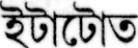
ইটাটোত
